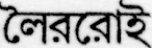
লৈররোই
